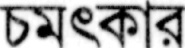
চমৎকার
